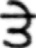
ਤੇ
